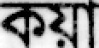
কয়া
